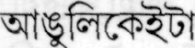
আঙুলিকেইটা
